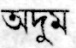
অদুম
